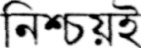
নিশ্চয়ই
